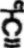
ਨੂੰ
